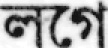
লগে
